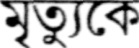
মৃত্যুকে
